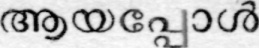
ആയപ്പോള്‍
